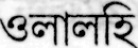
ওলালহি
